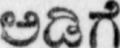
ಅಡಿಗೆ
